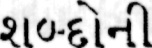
શબ્દોની
